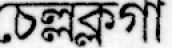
চেল্লক্লগা
